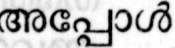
അപ്പോള്‍
